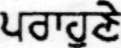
ਪਰਾਹੁਣੇ
